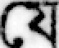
যে
